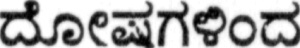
ದೋಷಗಳಿಂದ
